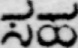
ಸಹ
